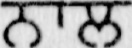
ਨਾਲ
